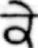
ਕੇ
